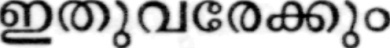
ഇതുവരേക്കും
